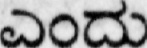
ಎಂದು
